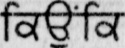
ਕਿਉਂਕਿ
